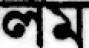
লম
